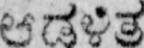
ಆಡಳಿತ
